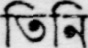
তিনি
